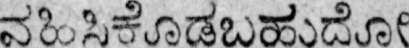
ವಹಿಸಿಕೊಡಬಹುದೋ
